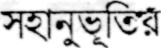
সহানুভূতির
